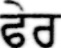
ਫੇਰ
